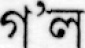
গ'ল
